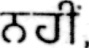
ਨਹੀਂ,
